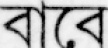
বাবে
